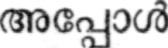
അപ്പോള്‍
